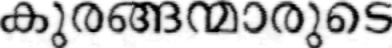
കുരങ്ങന്മാരുടെ
